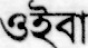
ওইবা
